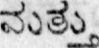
ಮತ್ತು
